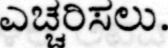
ಎಚ್ಚರಿಸಲು.
